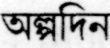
অল্পদিন
